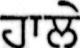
ਹਾਲੇ
